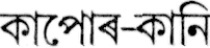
কাপোৰ-কানি
